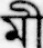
মী
